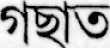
গছাত
